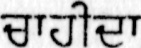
ਚਾਹੀਦਾ
